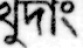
খুদাং
